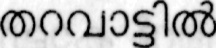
തറവാട്ടില്‍
